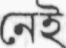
নেই
